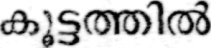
കൂട്ടത്തില്‍
